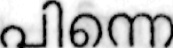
പിന്നെ
